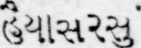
હૈયાસરસું
